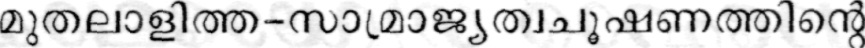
മുതലാളിത്ത-സാമ്രാജ്യത്വചൂഷണത്തിന്റെ
